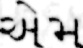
એમ
